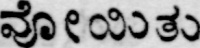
ವೋಯಿತು
